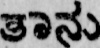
ತಾನು
